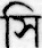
সি
